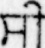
ਸੀ
